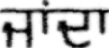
ਜਾਂਦਾ
